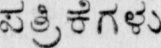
ಪತ್ರಿಕೆಗಳು
